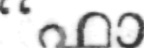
"ഫാ
